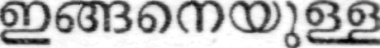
ഇങ്ങനെയുള്ള
